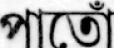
পাতোঁ
